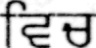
ਵਿਚ
